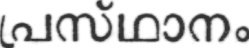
പ്രസ്ഥാനം
